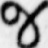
જ
